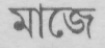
মাজে
